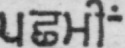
ਪਛਮੀਂ
